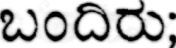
ಬಂದಿರು;
